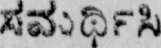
ಸಮರ್ಥಿಸಿ
